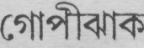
গোপীঝাক
